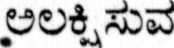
ಅಲಕ್ಷಿಸುವ
